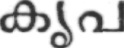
കൃപ
